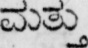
ಮತ್ತು
